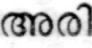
അരി
